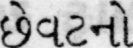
છેવટનો
